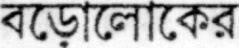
বড়োলোকের
